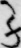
કે
